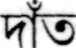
দাঁত
